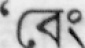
'বেং
